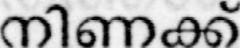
നിണക്ക്
